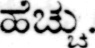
ಹೆಚ್ಚು.
